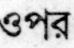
ওপর
